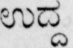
ಉದ್ದ
